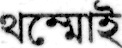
থম্মোই
